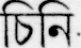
চিনি
